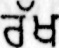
ਰੱਖ
